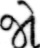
જો
